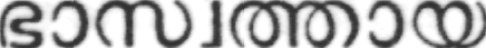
ഭാസ്വത്തായ
